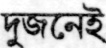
দুজনেই
